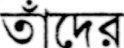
তাঁদের
